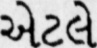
એટલે
